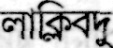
লাক্লিবদু
